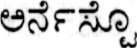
ಅರ್ನೆಸ್ಟೊ
